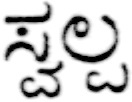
ಸ್ವಲ್ಪ
